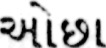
ઓછા
